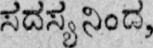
ಸದಸ್ಯನಿಂದ,
